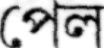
পেল
